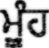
ਮੂੰਹ
